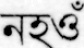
নহওঁ
